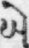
બે
